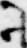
ને
